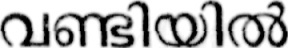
വണ്ടിയില്‍
